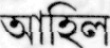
আহিল
